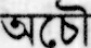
অচৌ
